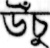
উঁচু
